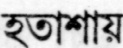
হতাশায়
